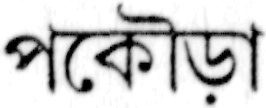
পকৌড়া
